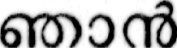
ഞാന്‍
